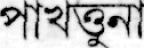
পাখত্তুনা
